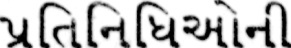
પ્રતિનિધિઓની
